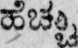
ಹೆಚ್ಚು
